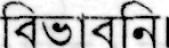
বিভাবনি।
